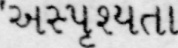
'અસ્પૃશ્યતા
